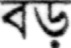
বড়
